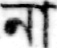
না
